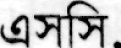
এসসি.
